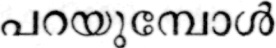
പറയുമ്പോള്‍
